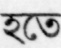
হতে
